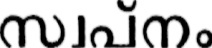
സ്വപ്നം
